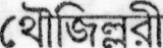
থৌজিল্লরী
